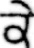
ਕੇ
